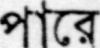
পারে
